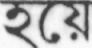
হয়ে
